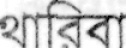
থারিবা
